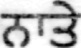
ਨਾਤੇ
